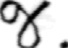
જ.
